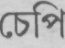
চেপি
